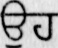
ਉਹ
